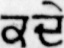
ਕਦੇ
